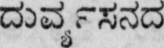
ದುರ್ವ್ಯಸನದ
